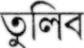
তুলিব
